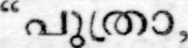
"പുത്രാ,
